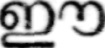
ഈ
